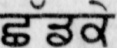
ਛੱਡਕੇ
